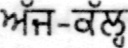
ਅੱਜ-ਕੱਲ੍ਹ
